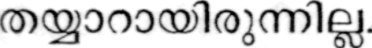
തയ്യാറായിരുന്നില്ല.
